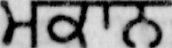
ਮਕਾਨ
